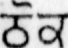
ਠੋਕ
